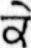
ਕੇ
